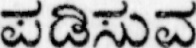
ಪಡಿಸುವ
